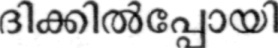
ദിക്കില്‍പ്പോയി
